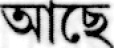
আছে
